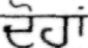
ਦੋਹਾਂ
